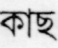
কাছ
